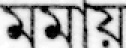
মমায়
